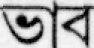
ভাব
